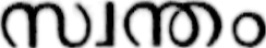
സ്വന്തം
